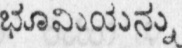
ಭೂಮಿಯನ್ನು
